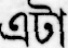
এটা
